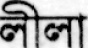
লীলা
